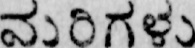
ಮರಿಗಳು
